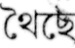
থৈছে
